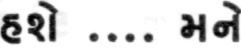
હશે......મને
